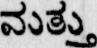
ಮತ್ತು
